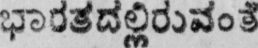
ಭಾರತದಲ್ಲಿರುವಂತೆ
